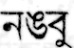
নঙবু
